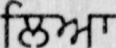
ਲਿਆ
